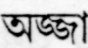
অজ্জা
